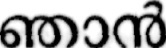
ഞാന്‍
